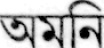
অমনি
